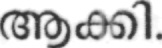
ആക്കി.
